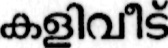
കളിവീട്
